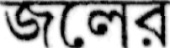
জলের
